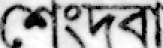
শেংদবা
